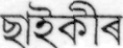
ছাইকীৰ
